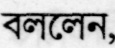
বললেন,
